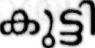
കുട്ടി
